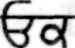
ਓਕ
